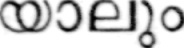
യാലും
